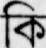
কি
